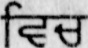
ਵਿਚ
